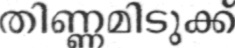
തിണ്ണമിടുക്ക്
